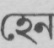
হেন
